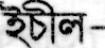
ইচীল-
